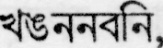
খঙননবনি,
